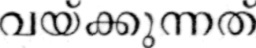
വയ്ക്കുന്നത്
